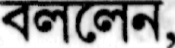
বললেন,
